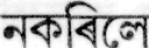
নকৰিলে
